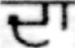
ਦਾ
